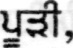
ਪੂੜੀ,
